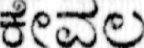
ಕೇವಲ
